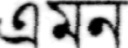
এমন
